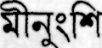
মীনুংশি
